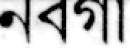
নবগা
